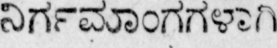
ನಿರ್ಗಮಾಂಗಗಳಾಗಿ
